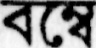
বম্বে
